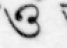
ও
